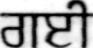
ਗਈ
